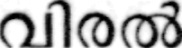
വിരല്‍
